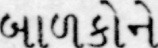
બાળકોને
